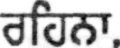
ਰਹਿਨਾ,
